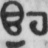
ਉਹ
